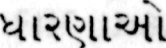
ધારણાઓ
